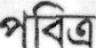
পবিত্র
